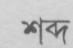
শব্দ
